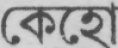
কেহো
